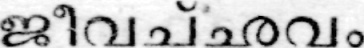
ജീവച്ഛവം
